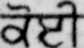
ਕੋਈ
